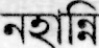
নহান্নি
